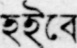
হইবে
